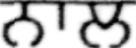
ਨਾਲ
